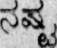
ನಷ್ಟ
